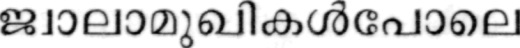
ജ്വാലാമുഖികള്‍പോലെ
